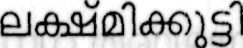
ലക്ഷ്മിക്കുട്ടി
